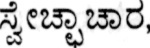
ಸ್ವೇಚ್ಛಾಚಾರ,
